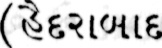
(હૈદરાબાદ
